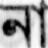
না
